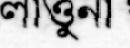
লোত্তুনা
